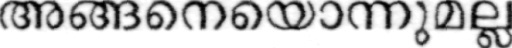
അങ്ങനെയൊന്നുമല്ല
